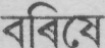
বৰিষে
